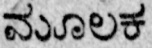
ಮೂಲಕ
